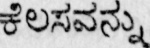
ಕೆಲಸವನ್ನು
